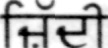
ਜ਼ਿੱਦੀ
